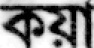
কয়া
